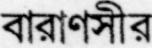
বারাণসীর
